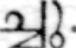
ച്ചു.
